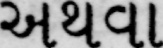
અથવા
